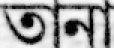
তানা
